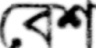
বেশ
